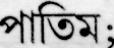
পাতিম;
